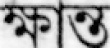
ক্ষান্ত
